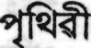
পৃথিৱী
